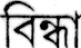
বিন্ধা
